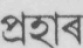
প্ৰহাৰ
